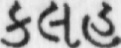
કલહ
